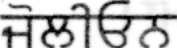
ਜੋਲੀਓਨ
